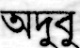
অদুবু
